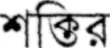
শক্তির
